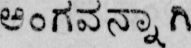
ಅಂಗವನ್ನಾಗಿ
